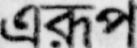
এরূপ
